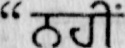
''ਨਹੀਂ
